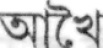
আখৈ
